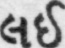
લઈ
